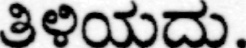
ತಿಳಿಯದು.
